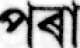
পৰা
